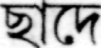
ছাদে
